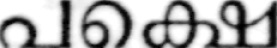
പക്ഷെ
